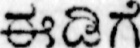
ಈಡಿಗೆ
